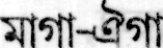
মাগা-ঐগা
